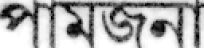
পামজনা
